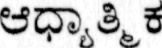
ಆಧ್ಯಾತ್ಮಿಕ
